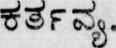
ಕರ್ತವ್ಯ.
